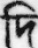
দি
